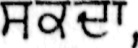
ਸਕਦਾ,
